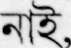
নাই,
